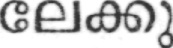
ലേക്കു
